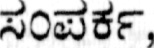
ಸಂಪರ್ಕ,
